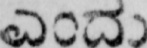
ಎಂದು
